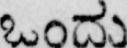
ಒಂದು
